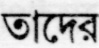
তাদের
